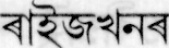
ৰাইজখনৰ
